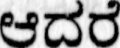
ಆದರೆ
